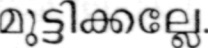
മുട്ടിക്കല്ലേ.
